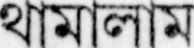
থামালাম
